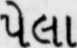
પેલા
